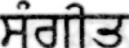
ਸੰਗੀਤ
